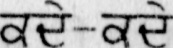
ਕਦੇ-ਕਦੇ
